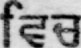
ਵਿਚ
